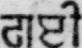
ਗਈ
